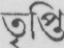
তৃপ্তি
